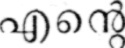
എന്റെ
